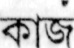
কাজ
